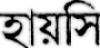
হায়সি
